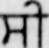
ਸੀ
